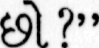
છો?"
